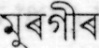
মুৰগীৰ
